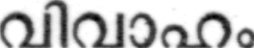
വിവാഹം
